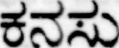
ಕನಸು
